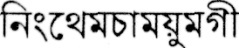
নিথেমচাময়ুমগী
